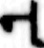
ન
